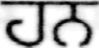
ਹਨ
